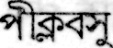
পীক্লবসু
